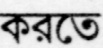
করতে
